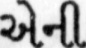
એની
